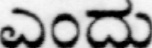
ಎಂದು
